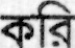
করি
